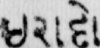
ઈરાદો
